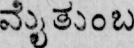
ಮೈತುಂಬ
